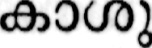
കാശു
